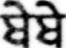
ਬੇਬੇ
